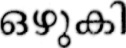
ഒഴുകി
